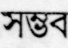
সম্ভব
